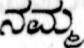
ನಮ್ಮ
